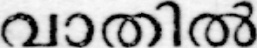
വാതില്‍
